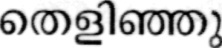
തെളിഞ്ഞു
